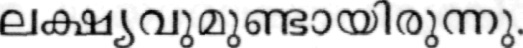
ലക്ഷ്യവുമുണ്ടായിരുന്നു.
